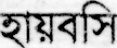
হায়বসি
